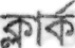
ক্লার্ক
